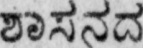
ಶಾಸನದ
